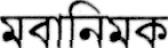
মবানিমক
